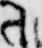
તો
